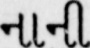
નાની
